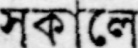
সকালে
